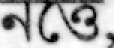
নত্তে,
